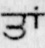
ਤਾਂ
